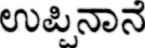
ಉಪ್ಪಿನಾನೆ
